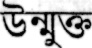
উন্মুক্ত
